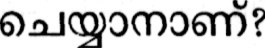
ചെയ്യാനാണ്?
